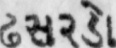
ઢસરડો
